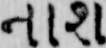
નાશ
